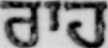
ਰਾਹ
